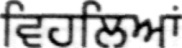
ਵਿਹਲਿਆਂ
